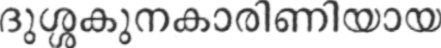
ദുശ്ശകുനകാരിണിയായ
